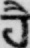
ਹੈ
